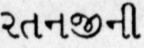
રતનજીની
